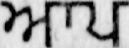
ਆਪ
